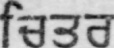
ਚਿਤਰ
